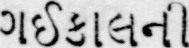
ગઈકાલની
